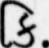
કિ.
